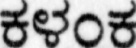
ಕಳಂಕ
